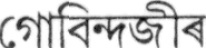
গোবিন্দজীৰ
